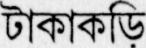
টাকাকড়ি
